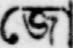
জো
